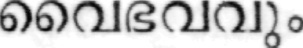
വൈഭവവും
